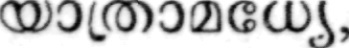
യാത്രാമധ്യേ,
